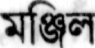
মঞ্জিল
